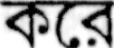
করে
